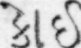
કોઈ
